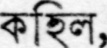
কহিল,
